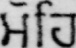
ਮੋਹਿ
